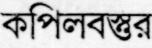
কপিলবস্তুর
